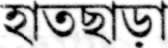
হাতছাড়া
